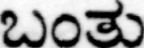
ಬಂತು
